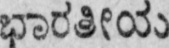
ಭಾರತೀಯ
